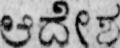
ಆದೇಶ
